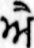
ਐ
